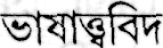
ভাষাত্ত্ববিদ
